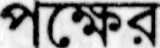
পক্ষের
